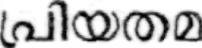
പ്രിയതമ
